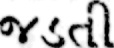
જડતી
